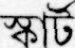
স্কাৰ্ট
